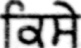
ਕਿਸੇ
